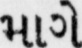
માગે
